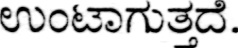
ಉಂಟಾಗುತ್ತದೆ.
